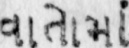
વાતોમાં
